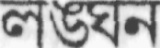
লঙ্ঘন
